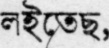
লইতেছ,
